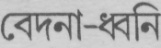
বেদনা-ধ্বনি
